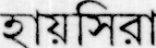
হায়সিরা
